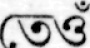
তেওঁ
